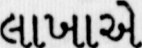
લાખાએ
